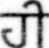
ਹੀ
